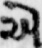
એ
